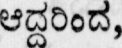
ಆದ್ದರಿಂದ,
